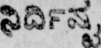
ನಿರ್ದಿಷ್ಟ
